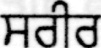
ਸਰੀਰ
